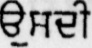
ਉਸਦੀ
